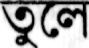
তুলে
